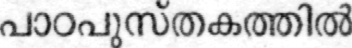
പാഠപുസ്തകത്തില്‍
